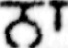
ਨਾ
